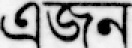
এজন
